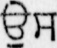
ਉਸ
